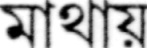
মাথায়
